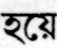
হয়ে
